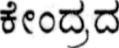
ಕೇಂದ್ರದ
